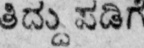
ತಿದ್ದುಪಡಿಗೆ
